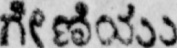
ಗೇಣಿಯು
